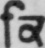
ਕਿ
